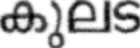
കുലട
